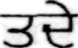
ਤਦੇ
